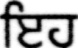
ਇਹ
